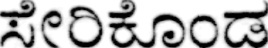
ಸೇರಿಕೊಂಡ
